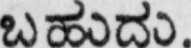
ಬಹುದು.
